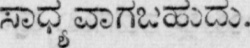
ಸಾಧ್ಯವಾಗಬಹುದು.
